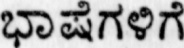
ಭಾಷೆಗಳಿಗೆ
